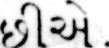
છીએ.
